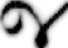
જ
